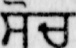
ਸੋਚ
